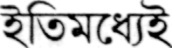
ইতিমধ্যেই
